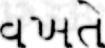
વખતે
